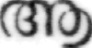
ആ
